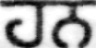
ਹਨ
